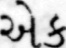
એક
